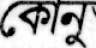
কোনু
